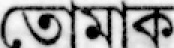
তোমাক
